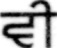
ਵੀ
